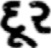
દૂર
